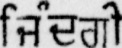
ਜਿੰਦਗੀ
